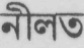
নীলত
